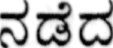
ನಡೆದ
